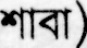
শাবা)
